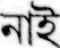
নাই
